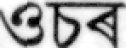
ওচৰ
